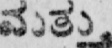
ಮತ್ತು
